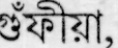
গুঁফীয়া,
